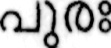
പുരഃ
